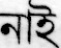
নাই
